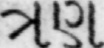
ત્રણ
